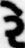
રે
